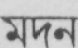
মদন
